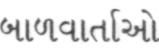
બાળવાર્તાઓ
